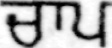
ਚਾਪ
